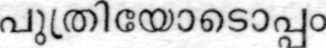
പുത്രിയോടൊപ്പം
